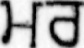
ਮਰ
